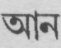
আন
